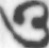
ও
